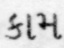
કામ
